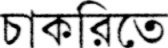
চাকরিতে
